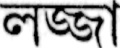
লজ্জা
